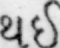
થઈ
